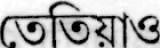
তেতিয়াও
